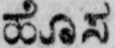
ಹೊಸ
